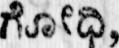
ಗೋಧಿ,
